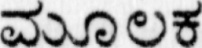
ಮೂಲಕ
